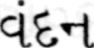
વંદન
